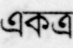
একত্র
